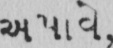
અપાવે,
